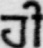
ਹੀ
